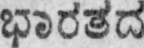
ಭಾರತದ
